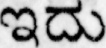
ಇದು
